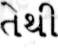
તેથી
